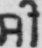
ਸੀ
